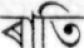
ৰাতি
